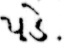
પડે.
